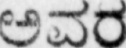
ಅವರ
